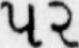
પર
